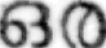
ഒര
